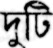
দুটি
